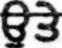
ਉਤੇ
